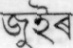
জুইৰ
